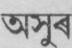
অসুৰ
